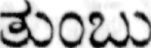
ತುಂಬು
